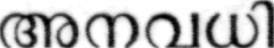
അനവധി
